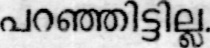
പറഞ്ഞിട്ടില്ല.
